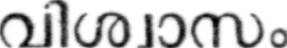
വിശ്വാസം
